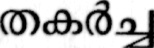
തകര്‍ച്ച
